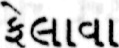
ફેલાવા
